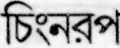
চিংনরপ
